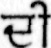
ਦੀ
